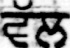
ਵੱਲ
